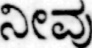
ನೀವು
